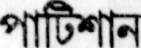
পাটিশান
